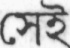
সেই
